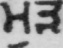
ਮੁੜ
